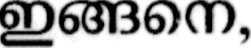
ഇങ്ങനെ,
